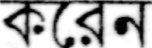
করেন
